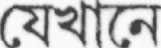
যেখানে
